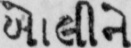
બોલીને
